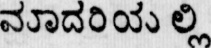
ಮಾದರಿಯಲ್ಲಿ
